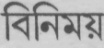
বিনিময়
